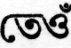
তেওঁ
